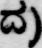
ದ)
